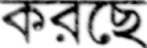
করছে
